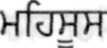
ਮਹਿਸੂਸ
